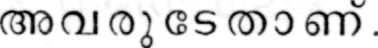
അവരുടേതാണ്.
